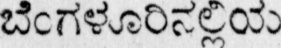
ಬೆಂಗಳೂರಿನಲ್ಲಿಯ
